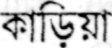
কাড়িয়া
